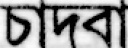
চাদবা
